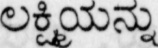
ಲಕ್ಷ್ಮಿಯನ್ನು
